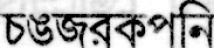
চঙজরকপনি
